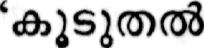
‘കൂടുതല്‍
